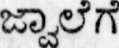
ಜ್ವಾಲೆಗೆ
